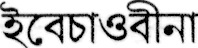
ইবেচাওবীনা
